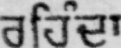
ਰਹਿੰਦਾ
